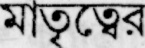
মাতৃত্বের
